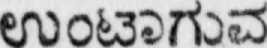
ಉಂಟಾಗುವ
